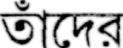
তাঁদের
